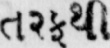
તરફથી
